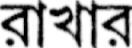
রাখার
